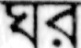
ঘর
